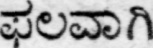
ಫಲವಾಗಿ
